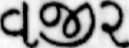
વજીર
